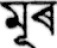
মূৰ
